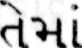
તેમાં
